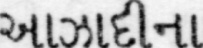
આઝાદીના
